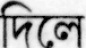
দিলে
